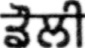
ਡੌਲੀ
